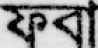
ফবা
